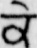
ਕੇ
